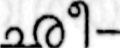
ഛീ-
